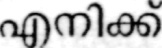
എനിക്ക്
